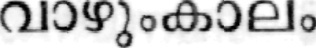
വാഴുംകാലം
